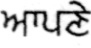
ਆਪਣੇ
